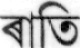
ৰাতি
